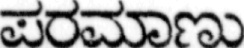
ಪರಮಾಣು
